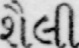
શૈલી
